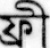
ফ্ৰী
